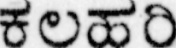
ಕಲಹರಿ
